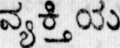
ವ್ಯಕ್ತಿಯ
